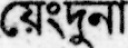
য়েংদুনা
